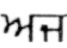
ਅਜ
